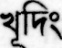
খূদিং
